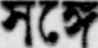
সঙ্গে
